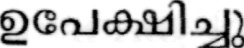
ഉപേക്ഷിച്ചു
